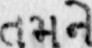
તમને
